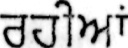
ਰਹੀਆਂ
